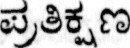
ಪ್ರತಿಕ್ಷಣ
